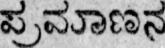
ಪ್ರಮಾಣನ
